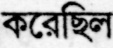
করেছিল
